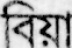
বিয়া
